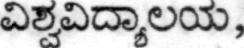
ವಿಶ್ವವಿದ್ಯಾಲಯ,
